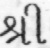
શ્રી
